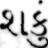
શકું
